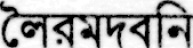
লৈরমদবনি
